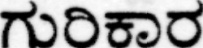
ಗುರಿಕಾರ
